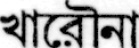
খারৌনা
